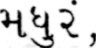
મધુરં,
